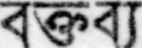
বক্তব্য
